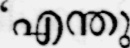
'എന്തു
